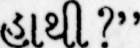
હાથી?"
